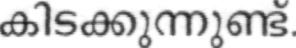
കിടക്കുന്നുണ്ട്.
